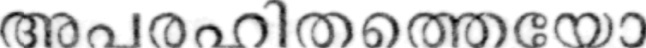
അപരഹിതത്തെയോ
